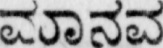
ಮಾನವ
